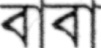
বাবা
